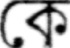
কে
